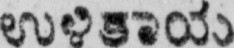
ಉಳಿತಾಯ
